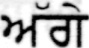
ਅੱਗੇ
